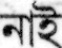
নাই
